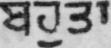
ਬਹੁਤਾ
